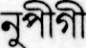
নুপীগী
